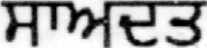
ਸਾਅਦਤ
